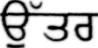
ਉੱਤਰ
